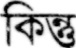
কিন্তু
